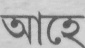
আহে
